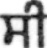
ਸੀ
